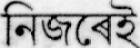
নিজৰেই
